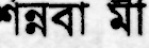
শন্নবা
